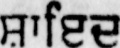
ਸ਼ਾਇਦ
